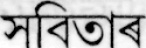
সবিতাৰ
